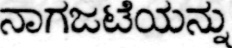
ನಾಗಜಟೆಯನ್ನು
